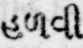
હળવી
